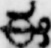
ಈ
